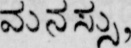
ಮನಸ್ಸು,
